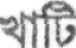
খাটি
